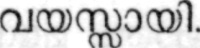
വയസ്സായി.
